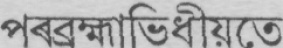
পৰব্ৰহ্মাভিধীয়তে
